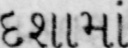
દશામાં
